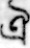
ঐ
